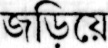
জড়িয়ে
